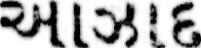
આઝાદ
